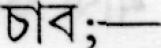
চাব;-
